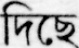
দিছে
